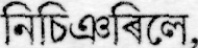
নিচিঞৰিলে,
